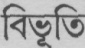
বিভূতি
